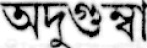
অদুগুম্বা
